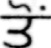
ਤੋਂ
